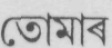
তোমাৰ
